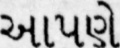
આપણે
